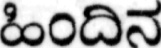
ಹಿಂದಿನ
